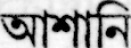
আশানি
